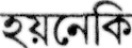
হয়নেকি
